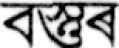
বস্তুৰ
